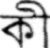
কী
